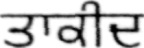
ਤਾਕੀਦ
